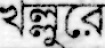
খল্লুরে
